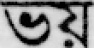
ভয়
